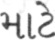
માટે
